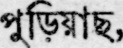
পুড়িয়াছ,
